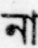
না
